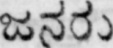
ಜನರು
